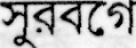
সুরবগে
